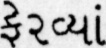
ફેરવ્યાં
